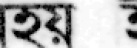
হয়
